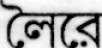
লৈরে
